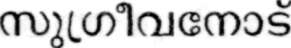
സുഗ്രീവനോട്
